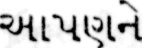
આપણને
